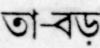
তা-বড়
